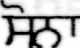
ਸੋਨਾ
